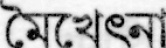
মৈখেৎনা
